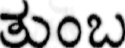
ತುಂಬ
